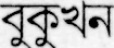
বুকুখন
